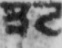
ਝਟ
